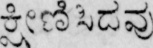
ಕ್ಷೀಣಿಸಿದವು
